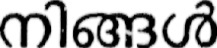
നിങ്ങള്‍
